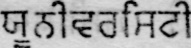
ਯੂਨੀਵਰਸਿਟੀ
